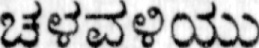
ಚಳವಳಿಯು
